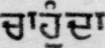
ਚਾਹੁੰਦਾ
